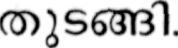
തുടങ്ങി.
